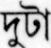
দুটা
